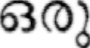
ഒരു
